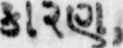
કારણ,
